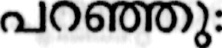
പറഞ്ഞു:
